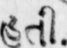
હતી.
